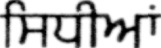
ਸਿਧੀਆਂ
